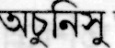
অচুনিসু
